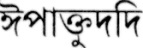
ঈপাক্তুদদি
